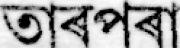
তাৰপৰা
